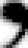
হায়রকই
